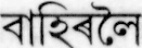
বাহিৰলৈ
